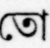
তো
